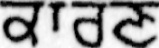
ਕਾਰਣ
